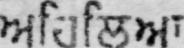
ਅਹਿਲਿਆ
